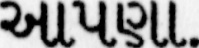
આપણા.
